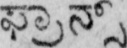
ಫ್ರಾನ್ಸ್
